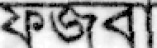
ফজবা
